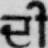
ਦੀ
